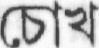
চোখ
